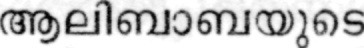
ആലിബാബയുടെ
